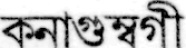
কনাগুম্বগী
